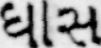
ઘાસ
